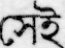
সেই
